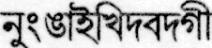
নুংঙাইখিদবদগী
